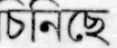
চিনিছে
